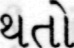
થતો
